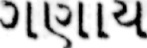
ગણાય
